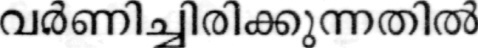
വര്‍ണിച്ചിരിക്കുന്നതില്‍
